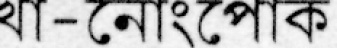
খা-নোংপোক
